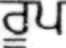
ਰੂਪ
